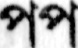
পপ
